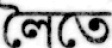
লৈতে
